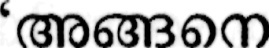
'അങ്ങനെ
